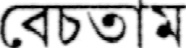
বেচতাম
